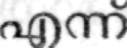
എന്ന്
